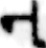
ન
